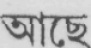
আছে
